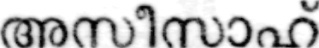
അസീസാഹ്
